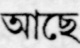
আছে
